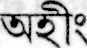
অহীং
